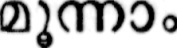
മൂന്നാം
